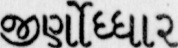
જીર્ણોધ્ધાર
